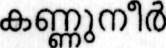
കണ്ണുനീര്‍
